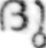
ദു
